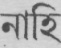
নাহি
